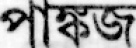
পাঙ্কজ
